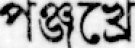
পঞ্জখ্রে
